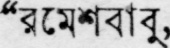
‘‘রমেশবাবু,
